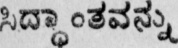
ಸಿದ್ಧಾಂತವನ್ನು
